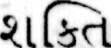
શક્તિ
